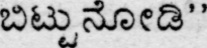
ಬಿಟ್ಟುನೋಡಿ”
